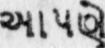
આપણે
